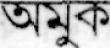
অমুক
